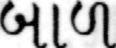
બાળ
